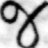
જ
